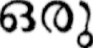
ഒരു
